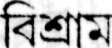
বিশ্রাম
